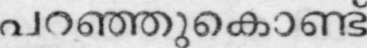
പറഞ്ഞുകൊണ്ട്
